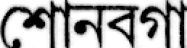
শোনবগা
